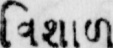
વિશાળ
